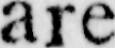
are
